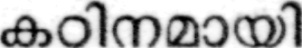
കഠിനമായി
